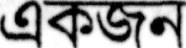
একজন
